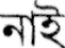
নাই
